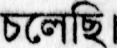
চলেছি।
